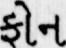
ફોન
